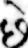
છે
